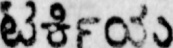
ಟರ್ಕಿಯ
